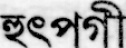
হুৎপগী
